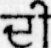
ਦੀ
